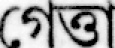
গেত্তা
